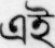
এই
